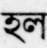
হল
